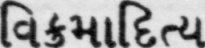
વિક્રમાદિત્ય
